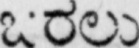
ಬರಲು
